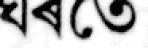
ঘৰতে
